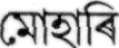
মোহাৰি
